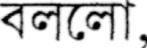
বললো,
